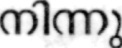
നിന്നു
